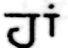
ਹਾਂ
